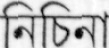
নিচিনা
